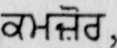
ਕਮਜ਼ੋਰ,
